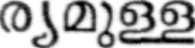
ര്യമുള്ള
